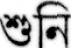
শুনি
